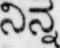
ನಿನ್ನ
